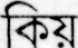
কিয়
